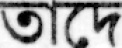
তাদে
